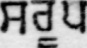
ਸਰੂਪ
